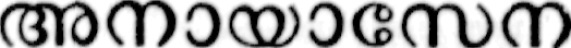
അനായാസേന
